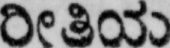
ರೀತಿಯ
